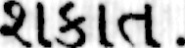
શકાત.
